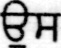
ਉਸ
